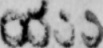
ಯು
